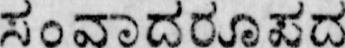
ಸಂವಾದರೂಪದ
